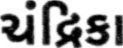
ચંદ્રિકા
